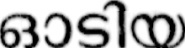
ഓടിയ
